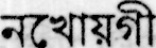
নখোয়গী
